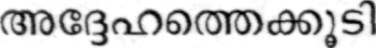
അദ്ദേഹത്തെക്കൂടി
